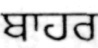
ਬਾਹਰ
